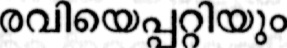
രവിയെപ്പറ്റിയും
